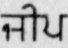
ਜੀਪ
